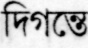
দিগন্তে
